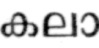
കലാ
